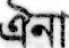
ঐনা
